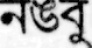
নঙবু
